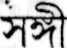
সঙ্গী
